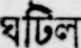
ঘটিল
